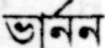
ভার্নন
